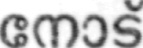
നോട്
